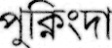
পুক্নিংদা
